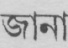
জানা
